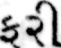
ફરી
